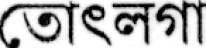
তোৎলগা
